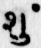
શું
